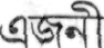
এজনী
